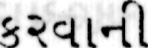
કરવાની
